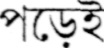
পড়েই
